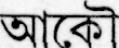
আকৌ
